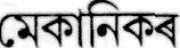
মেকানিকৰ
